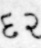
દર
